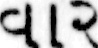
વાર
